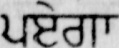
ਪਏਗਾ
